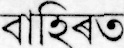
বাহিৰত
